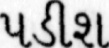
પડીશ
